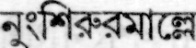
নুংশিরুরমাল্লে
